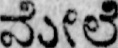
ಮೇಲೆ
